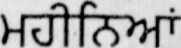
ਮਹੀਨਿਆਂ
